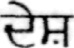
ਦੇਸ਼
